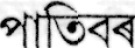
পাতিবৰ
